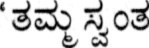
'ತಮ್ಮಸ್ವಂತ
